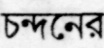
চন্দনের
